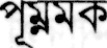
পূম্নমক
